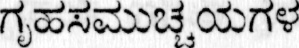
ಗೃಹಸಮುಚ್ಚಯಗಳ
